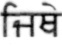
ਜਿਥੇ
